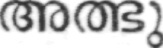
അത്ഭു
